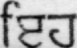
ਇਹ
